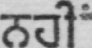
ਨਹੀਂ
